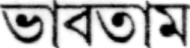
ভাবতাম
